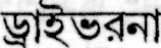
ড্রাইভরনা
